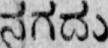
ನಗದು
